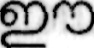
ഈ
